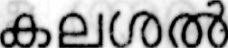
കലശല്‍
